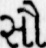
સૌ
